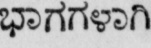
ಭಾಗಗಳಾಗಿ
